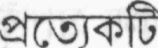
প্রত্যেকটি
